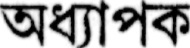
অধ্যাপক
